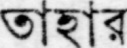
তাহার
